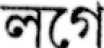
লগে
